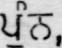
ਪੁੰਨ,
